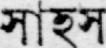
সাহস
